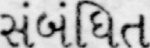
સંબંધિત
